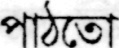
পাঠতো
